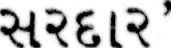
સરદાર'
